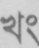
খং
